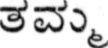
ತಮ್ಮ
